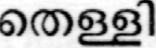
തെള്ളി
